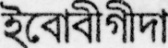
ইবোবীগীদা
